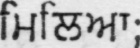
ਮਿਲਿਆ;
